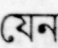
যেন
